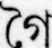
গৈ
